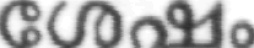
ശേഷം
